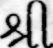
શ્રી
